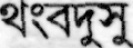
থংবদুসু
